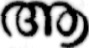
ആ
